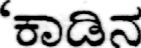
'ಕಾಡಿನ
